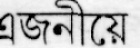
এজনীয়ে
